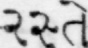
રસ્તે
